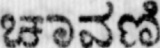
ಚಾವಣಿ
